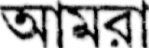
আমরা
